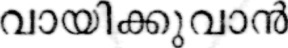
വായിക്കുവാന്‍
